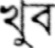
খুব
